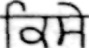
ਕਿਸੇ
